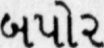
બપોર
